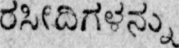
ರಸೀದಿಗಳನ್ನು
